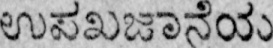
ಉಪಖಜಾನೆಯ
